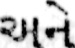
અને
